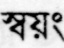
স্বয়ং
